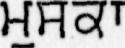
ਮੁਸਕਾ
